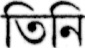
তিনি
